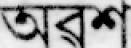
অৱশ
